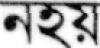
নহয়
